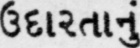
ઉદારતાનું
